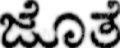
ಜೊತೆ
